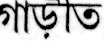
গাড়ীত
